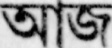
আজ
